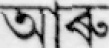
আৰু
